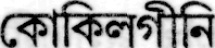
কোকিলগীনি
